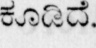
ಕೂಡಿದೆ.
